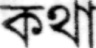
কথা
